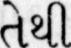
તેથી
